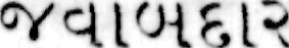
જવાબદાર
